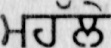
ਮਹੱਲੇ
